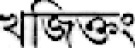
খজিক্তং
